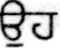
ਉਹ
